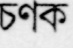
চণক
